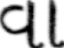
વા
